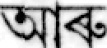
আৰু
